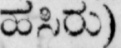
ಹಸಿರು)
